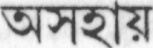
অসহায়
